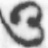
ও
